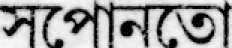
সপোনতো
